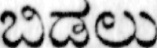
ಬಿಡಲು
